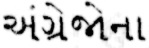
અંગ્રેજોના
